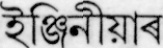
ইঞ্জিনীয়াৰ
